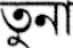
তুনা
